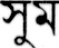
সুম
